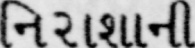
નિરાશાની
